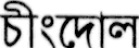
চীংদোল
